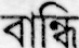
বান্ধি
